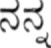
ನನ್ನ
